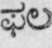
ಫಲ
